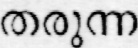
തരുന്ന
